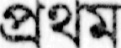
প্রথম
